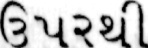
ઉપરથી
